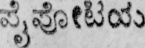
ಪೈಪೋಟಿಯ
